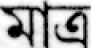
মাত্র
